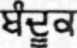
ਬੰਦੂਕ
